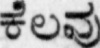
ಕೆಲವು
